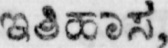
ಇತಿಹಾಸ,
